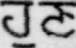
ਹੁਣ
